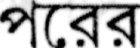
পরের
